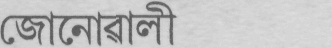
জোনোৱালী
